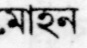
মোহন
